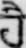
ਹੈ
